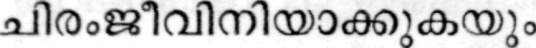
ചിരംജീവിനിയാക്കുകയും
